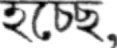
হচ্ছে,
